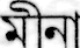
মীনা
